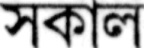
সকাল
